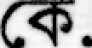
কে.
